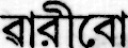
ৱারীবো
